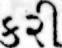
કરી
